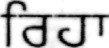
ਰਿਹਾ
